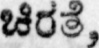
ಚಿರತೆ,
